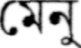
মেনু
